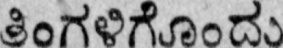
ತಿಂಗಳಿಗೊಂದು
